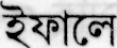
ইফালে
